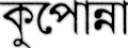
কুপোন্না
